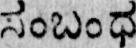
ಸಂಬಂಧ
